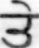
ਤੇ
